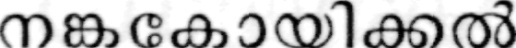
നങ്കകോയിക്കല്‍
